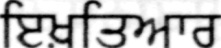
ਇਖ਼ਤਿਆਰ
